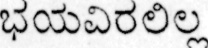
ಭಯವಿರಲಿಲ್ಲ
